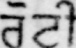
ਰੋਟੀ
